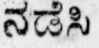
ನಡೆಸಿ
